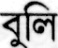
বুলি
